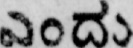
ಎಂದು
